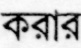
করার
